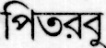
পিতরবু
